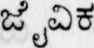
ಜೈವಿಕ
